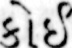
કોઈ
